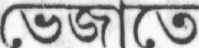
ভেজাতে
